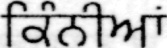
ਕਿੰਨੀਆਂ
